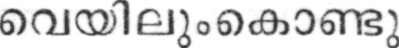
വെയിലുംകൊണ്ടു
